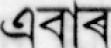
এবাৰ
